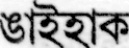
ঙাইহাক
